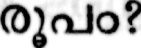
രൂപം?
